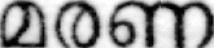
മരണ
